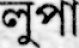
লুপা
